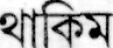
থাকিম
